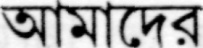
আমাদের
